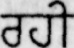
ਰਹੀ
